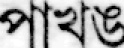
পখঙ
